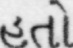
હતો
